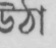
উঠা
